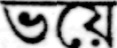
ভয়ে
